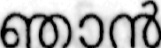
ഞാന്‍
